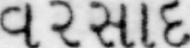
વરસાદ
